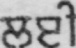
ਲਈ
